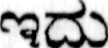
ಇದು
